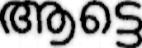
ആട്ടെ
